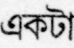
একটা
